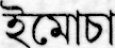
ইমোচা
